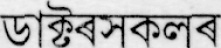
ডাক্টৰসকলৰ
